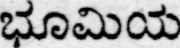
ಭೂಮಿಯ
